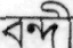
বন্দী
